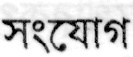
সংযোগ
